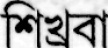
শিখ্রবা
